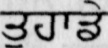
ਤੁਹਾਡੇ
